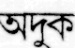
অদুক
